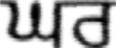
ਘਰ
